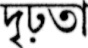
দৃঢ়তা
